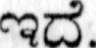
ಇದೆ.
